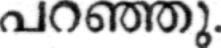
പറഞ്ഞു.
